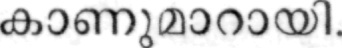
കാണുമാറായി.
